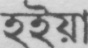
হইয়া
